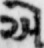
એ
